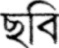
ছবি
